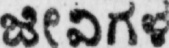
ಜೀವಿಗಳ
